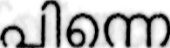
പിന്നെ
